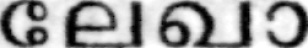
ലേഖാ
